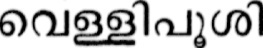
വെള്ളിപൂശി
